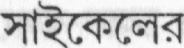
সাইকেলের
